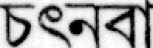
চৎনবা
